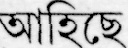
আহিছে
